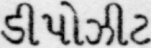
ડીપોઝીટ
